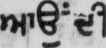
ਆਉਂਦੀ
